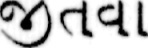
જીતવા
